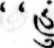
"હું
